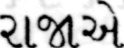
રાજાએ
